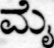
ಮೈ
